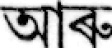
আৰু
